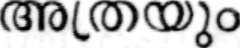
അത്രയും
